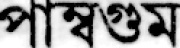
পাম্বগুম
